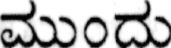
ಮುಂದು
